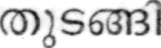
തുടങ്ങി
